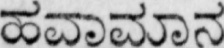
ಹವಾಮಾನ
